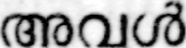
അവള്‍
